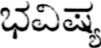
ಭವಿಷ್ಯ
